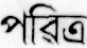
পৱিত্র
